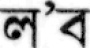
ল'ব
